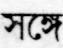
সঙ্গে
